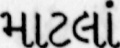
માટલાં
